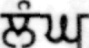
ਲੰਘ
